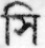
সি
